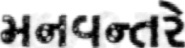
મનવન્તરે
